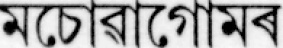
মচোৱাগোমৰ
